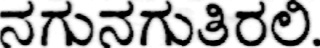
ನಗುನಗುತಿರಲಿ.
